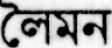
লৈমন
